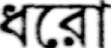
ধরো
